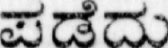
ಪಡೆದು
